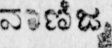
ವಾಣಿಜ್ಯ
